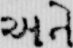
અને
